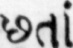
છતાં
